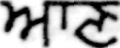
ਆਣ
